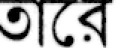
তারে
